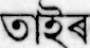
তাইৰ
